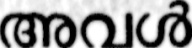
അവള്‍
